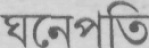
ঘনেপতি
